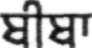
ਬੀਬਾ
